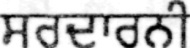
ਸਰਦਾਰਨੀ
